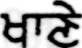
ਖਾਣੇ
